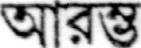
আরম্ভ
